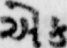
એક
